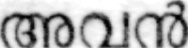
അവന്‍
